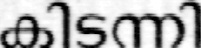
കിടന്നി
